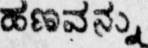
ಹಣವನ್ನು
